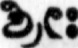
ಶ್ರೀಃ
